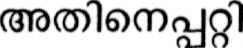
അതിനെപ്പറ്റി
